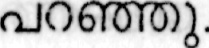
പറഞ്ഞു.
